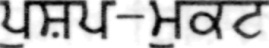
ਪੁਸ਼ਪ-ਮੁਕਟ
